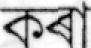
কৰা
